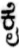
ಕೈ
